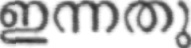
ഇന്നതു
